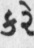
કરે
